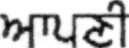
ਆਪਣੀ
